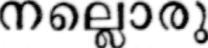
നല്ലൊരു
